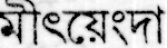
মীৎয়েংদা
